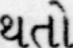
થતો
